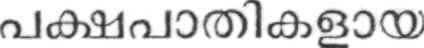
പക്ഷപാതികളായ
